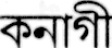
কনাগী
